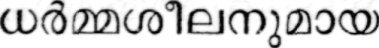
ധര്‍മ്മശീലനുമായ
